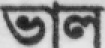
ভাল
